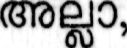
അല്ലാ,
